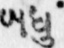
બધું
